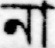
না
